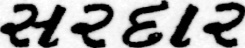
સરદાર
